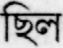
ছিল
